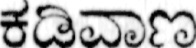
ಕಡಿವಾಣ
